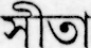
সীতা
